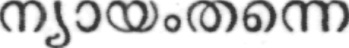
ന്യായംതന്നെ
